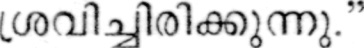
ശ്രവിച്ചിരിക്കുന്നു.”
